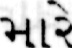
મારે
